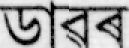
ডাৱৰ
